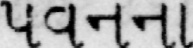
પવનના
